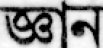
জ্ঞান
